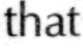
that
